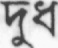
দুধ
